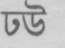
ঢউ
